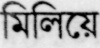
মিলিয়ে
